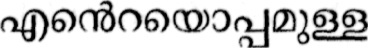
എന്റെയൊപ്പമുള്ള
